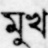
মুখ
